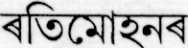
ৰতিমোহনৰ
